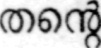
തന്റെ
